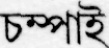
চম্পাই
